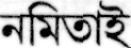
নমিতাই
